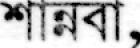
শান্নবা,
